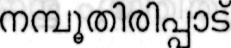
നമ്പൂതിരിപ്പാട്
